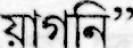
য়াগনি”
